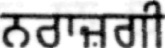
ਨਰਾਜ਼ਗੀ
